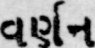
વર્ણન
